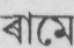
ৰামে
